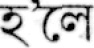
হ'লে
